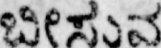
ಬೀಸುವ
